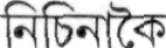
নিচিনাকৈ
